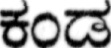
ಕಂಡ
